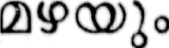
മഴയും
